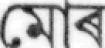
মোৰ
